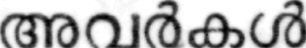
അവര്‍കള്‍
